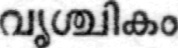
വൃശ്ചികം
